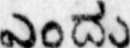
ಎಂದು
